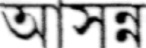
আসন্ন
